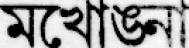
মখোঙনা
